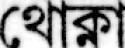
থোক্না
